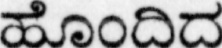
ಹೊಂದಿದ
